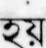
হয়
